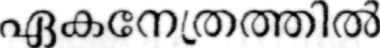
ഏകനേത്രത്തില്‍
